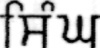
ਸਿੰਘ
